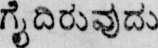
ಗೈದಿರುವುದು
